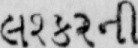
લશ્કરની
